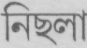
নিছলা
